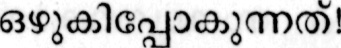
ഒഴുകിപ്പോകുന്നത്!
